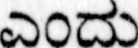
ಎಂದು
